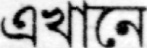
এখানে
